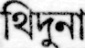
থিদুনা
